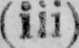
(iii)
